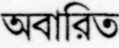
অবারিত
